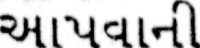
આપવાની
